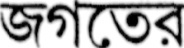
জগতের
